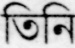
তিনি
